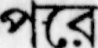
পরে
